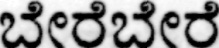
ಬೇರೆಬೇರೆ
